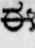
ಈ
